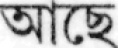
আছে
